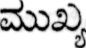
ಮುಖ್ಯ
